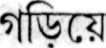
গড়িয়ে
